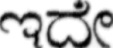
ಇದೇ
